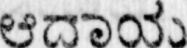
ಆದಾಯ
